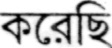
করেছি
